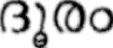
ദൂരം
